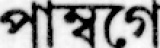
পাম্বগে
